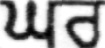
ਘਰ
